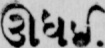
ઊધઈ.
